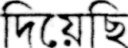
দিয়েছি
